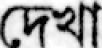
দেখা
